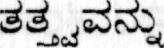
ತತ್ತ್ವವನ್ನು
